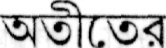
অতীতের
